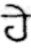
ਹੇ
